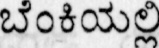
ಬೆಂಕಿಯಲ್ಲಿ
